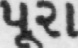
પૂરા
